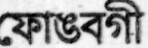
ফোঙবগী
